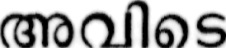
അവിടെ
